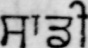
ਸਾਡੀ
